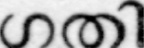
ഗതി
